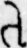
તે
